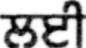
ਲਈ
